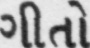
ગીતો
